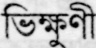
ভিক্ষুণী
